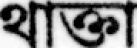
থাক্তা
